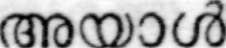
അയാള്‍
